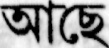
আছে
